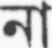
না
